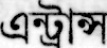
এন্ট্রান্স
